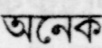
অনেক
